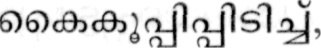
കൈകൂപ്പിപ്പിടിച്ച്,
